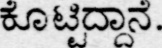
ಕೊಟ್ಟಿದ್ದಾನೆ.
